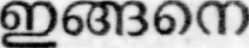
ഇങ്ങനെ
